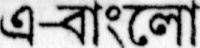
এ-বাংলো
